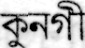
কুনগী
